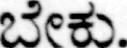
ಬೇಕು.
